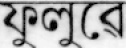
ফুলুৱে
